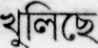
খুলিছে
